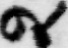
જ
